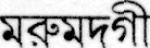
মরুমদগী
